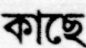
কাছে
